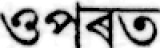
ওপৰত
